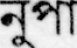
নুপা
